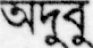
অদুবু
